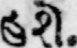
હશે.
